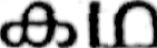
കഥ
